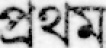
প্রথম
